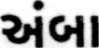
અંબા
